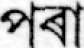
পৰা
